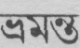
ভ্ৰমন্ত
